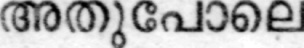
അതുപോലെ
